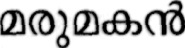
മരുമകന്‍
